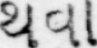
થવા
